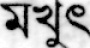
মখুৎ
